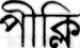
পীক্লি
